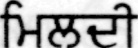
ਮਿਲਦੀ
